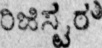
ರಿಜಿಸ್ಟರು
